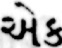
એક
